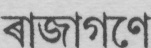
ৰাজাগণে
